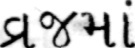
વ્રજમાં
